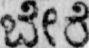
ಬೇರೆ
